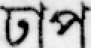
ঢাপ
